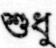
শুধু
